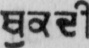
ਥੁਕਦੀ
